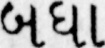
બધા
